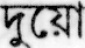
দুয়ো
